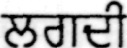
ਲਗਦੀ
